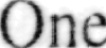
One
